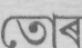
তোৰ
